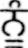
ਨੂੰ
